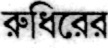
রুধিরের
